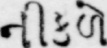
નીકળે
